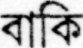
বাকি
